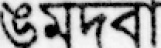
ঙমদবা
